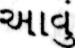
આવું
